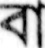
বা
